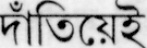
দাঁতিয়েই
